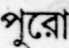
পুরো
